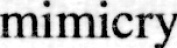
mimicry
